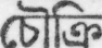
চৌক্রি
